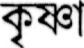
কৃষ্ণা
